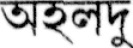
অহলদু
